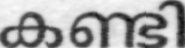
കണ്ടി
